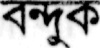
বন্দুক
